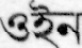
ওইন
